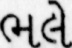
ભલે
